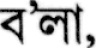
ব'লা,
